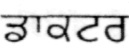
ਡਾਕਟਰ
